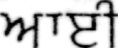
ਆਈ
